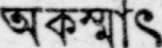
অকস্মাৎ
